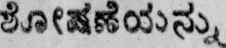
ಶೋಷಣೆಯನ್ನು
